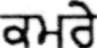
ਕਮਰੇ
